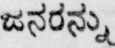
ಜನರನ್ನು
